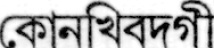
কোনখিবদগী
